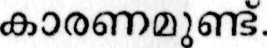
കാരണമുണ്ട്.
